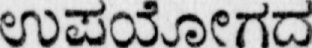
ಉಪಯೋಗದ
